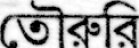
তৌরুরি
